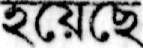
হয়েছে
